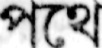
পথে
